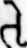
તે
